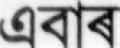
এবাৰ
